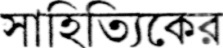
সাহিত্যিকের
